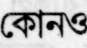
কোনও
